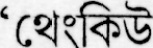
'থেংকিউ
